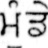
ਮੁੰਡੇ
